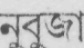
নুবুজা
